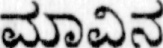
ಮಾವಿನ
